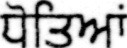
ਧੋਤਿਆਂ
